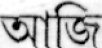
আজি
